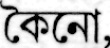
কৈনো,
